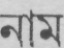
নাম
